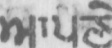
ਆਪਣੇ
